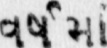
વર્ષમાં
